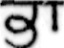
ਭਾ
